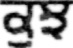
ਕੁਝ
